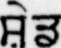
ਸ਼ੇਡ
